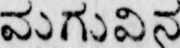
ಮಗುವಿನ
